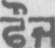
ਫੌਜ
